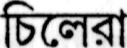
চিলেরা
